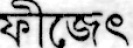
ফীজেৎ
